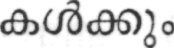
കള്‍ക്കും
